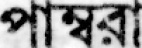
পাম্বরা
